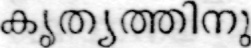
കൃത്യത്തിനു
